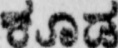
ಕೂಡ
